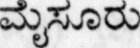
ಮೈಸೂರು
